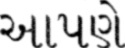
આપણે
